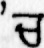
'ਚ
